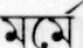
মর্মে
